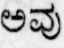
ಅವು
